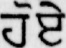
ਹੋਏ
